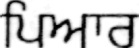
ਪਿਆਰ
